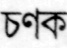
চণক
